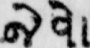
જેવો
